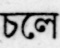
চলে
